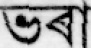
ভৰা
